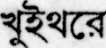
খুইথরে
